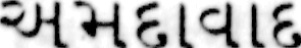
અમદાવાદ
